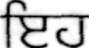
ਇਹ
